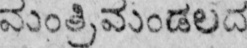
ಮಂತ್ರಿಮಂಡಲದ
